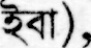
ইবা),
